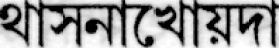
থাসনাখোয়দা
